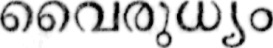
വൈരുധ്യം
